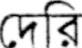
দেরি
